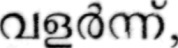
വളര്‍ന്ന്,
